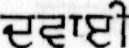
ਦਵਾਈ
